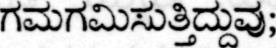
ಗಮಗಮಿಸುತ್ತಿದ್ದುವು;
